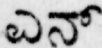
ಎನ್
